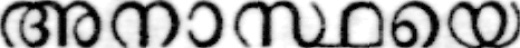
അനാസ്ഥയെ
